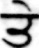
ਤੇ
